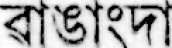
ৱাঙাংদা
